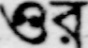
ওর
